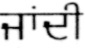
ਜਾਂਦੀ
